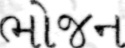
ભોજન
